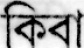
কিবা
